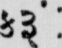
કરૂં:
